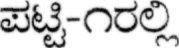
ಪಟ್ಟಿ-೧ರಲ್ಲಿ
